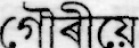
গৌৰীয়ে
